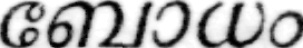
ബോധം
